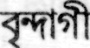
বৃন্দাগী
